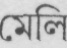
মেলি
